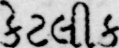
કેટલીક
